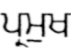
ਪ੍ਰਮੁਖ
